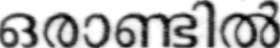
ഒരാണ്ടില്‍
